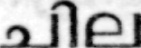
ചില
